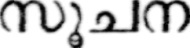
സൂചന
